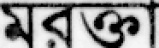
মরক্তা
